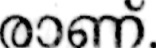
രാണ്.
